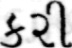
કરી
